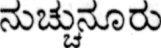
ನುಚ್ಚುನೂರು
